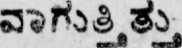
ವಾಗುತ್ತಿತ್ತು
